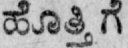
ಹೊತ್ತಿಗೆ
